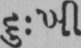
દુઃખી
